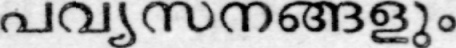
പവ്യസനങ്ങളും
